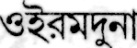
ওইরমদুনা
